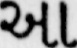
આ
